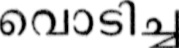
വൊടിച്ച
